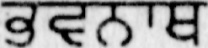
ਭਵਨਾਥ
